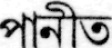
পানীত
